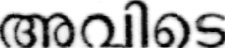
അവിടെ
